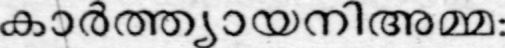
കാര്‍ത്ത്യായനിഅമ്മ:
